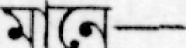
মানে-
